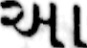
આ
